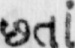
છતાં
